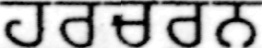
ਹਰਚਰਨ
